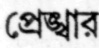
প্রেঙ্খার
